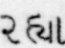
રહ્યા
